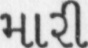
મારી
